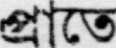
প্রাতে
